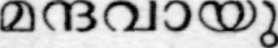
മന്ദവായു
